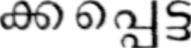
ക്കപ്പെട്ട
